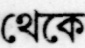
থেকে
